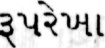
રૂપરેખા
